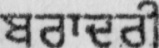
ਬਰਾਦਰੀ
